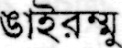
ঙাইরম্মু
